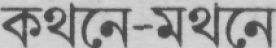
কথনে-মথনে
